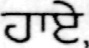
ਹਾਏ,
